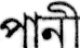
পানী
